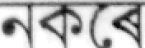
নকৰে
